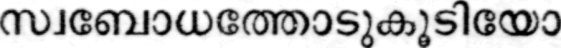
സ്വബോധത്തോടുകൂടിയോ
